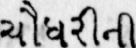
ચૌધરીની
